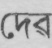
দেৱ
